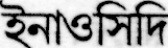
ইনাওসিদি
